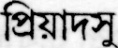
প্রিয়াদসু
